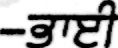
-ਭਾਈ
